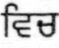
ਵਿਚ
